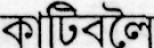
কাটিবলৈ
